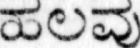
ಹಲವು
